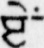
ਏਂ
